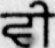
ਵੀ
